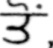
ਤੋਂ,
